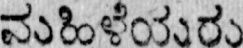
ಮಹಿಳೆಯರು
